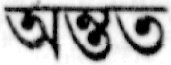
অন্তত
